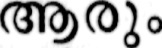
ആരും
